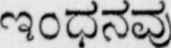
ಇಂಧನವು
